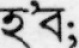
হ'ব;
